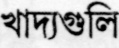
খাদ্যগুলি
